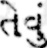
તેવું
